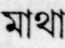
মাথা
